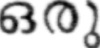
ഒരു
